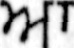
ਆ
